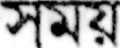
সময়
